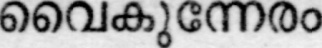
വൈകുന്നേരം
